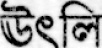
ঊৎলি
